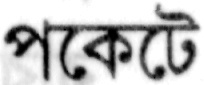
পকেটে
